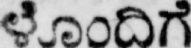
ಳೊಂದಿಗೆ
